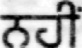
ਨਹੀਂ
